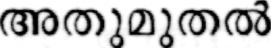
അതുമുതല്‍
